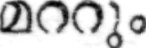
മററും
